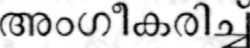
അംഗീകരിച്ച്
